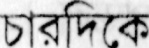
চারদিকে
